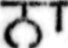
ਨਾ
